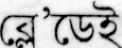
ব্লে'ডেই
